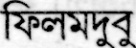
ফিলমদুবু
